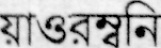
য়াওরম্বনি
